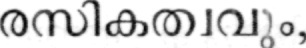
രസികത്വവും,
